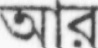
আর
